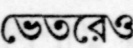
ভেতরেও
